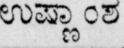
ಉಷ್ಣಾಂಶ
